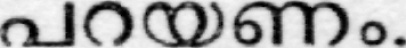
പറയണം.
